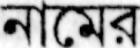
নামের
